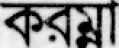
করম্না
